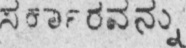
ಸರ್ಕಾರವನ್ನು
